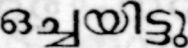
ഒച്ചയിട്ടു
